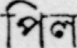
পিল
